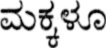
ಮಕ್ಕಳೂ
